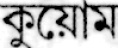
কুয়োম
